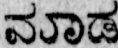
ಮಾಡ
